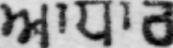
ਆਧਾਰ
